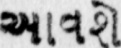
આવશે
